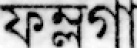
ফম্লগা
